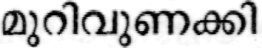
മുറിവുണക്കി
